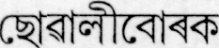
ছোৱালীবোৰক
